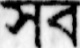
সব
